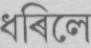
ধৰিলে
